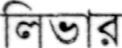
লিভার
